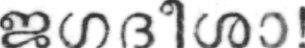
ജഗദീശാ!
